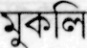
মুকলি
